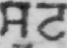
ਸੁਟ
